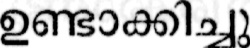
ഉണ്ടാക്കിച്ചു
